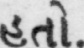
હતો.
